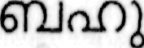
ബഹു
